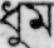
ধুম
